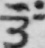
ਤੋਂ
